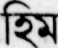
হিম
